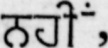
ਨਹੀਂ,
